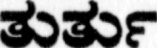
ತುರ್ತು
